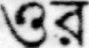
ওর
